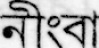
নীংবা
